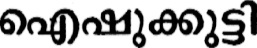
ഐഷുക്കുട്ടി
